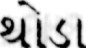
થોડા
